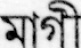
মাগী
